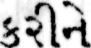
કરીને
